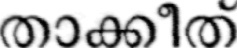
താക്കീത്
